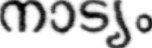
നാട്യം
